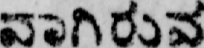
ವಾಗಿರುವ
